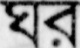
ঘর
